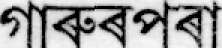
গাৰুৰপৰা
